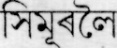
সিমূৰলৈ
